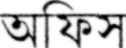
অফিস
